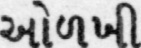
ઓળખી
